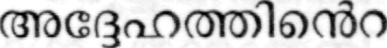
അദ്ദേഹത്തിന്റെ
